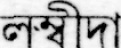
লম্বীদা
